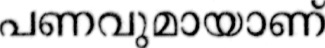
പണവുമായാണ്
